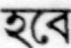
হবে
